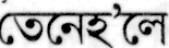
তেনেহ'লে
